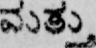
ಮತ್ತು
